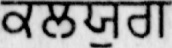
ਕਲਯੁਗ
